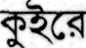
কুইরে
